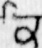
ਕਿ
